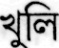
খুলি
